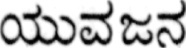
ಯುವಜನ
